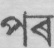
পৰ
